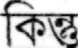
কিন্তু
